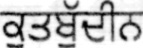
ਕੁਤਬੁੱਦੀਨ
